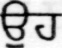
ਉਹ
